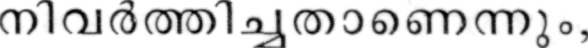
നിവര്‍ത്തിച്ചതാണെന്നും,
